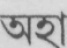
অহা
